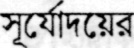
সূর্যোদয়ের
